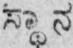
ಸ್ಥಾನ
